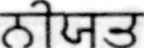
ਨੀਯਤ
